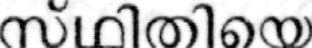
സ്ഥിതിയെ
